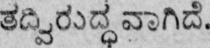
ತದ್ವಿರುದ್ಧವಾಗಿದೆ.
